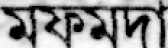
মফমদা
